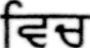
ਵਿਚ
